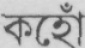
কহোঁ
